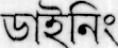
ডাইনিং
